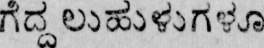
ಗೆದ್ದಲುಹುಳುಗಳೂ
